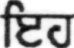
ਇਹ
